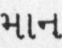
માન
